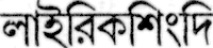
লাইরিকশিংদি
